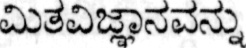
ಮಿತವಿಜ್ಞಾನವನ್ನು
